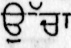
ਉੱਚਾ
